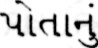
પોતાનું
